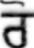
ਰੋ
